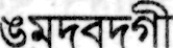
ঙমদবদগী
